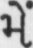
મેં
